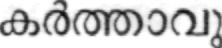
കര്‍ത്താവു
